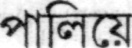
পালিয়ে
